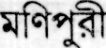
মণিপুরী
